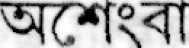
অশেংবা
